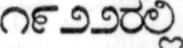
೧೯೨೨ರಲ್ಲಿ
